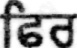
ਫਿਰ
